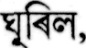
ঘূৰিল,
